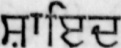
ਸ਼ਾਇਦ
